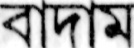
বাদাম
